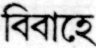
বিবাহে
